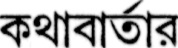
কথাবার্তার
